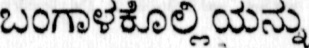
ಬಂಗಾಳಕೊಲ್ಲಿಯನ್ನು
